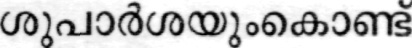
ശുപാര്‍ശയുംകൊണ്ട്
